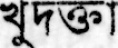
খুদ্ক্তা
